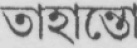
তাহান্তো
